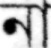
না
